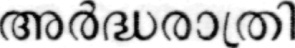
അര്‍ദ്ധരാത്രി
